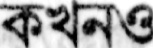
কখনও
